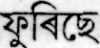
ফুৰিছে
